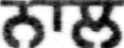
ਨਾਲ
